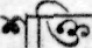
শক্তি
